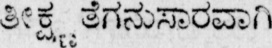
ತೀಕ್ಷ್ಣತೆಗನುಸಾರವಾಗಿ
